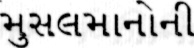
મુસલમાનોની
